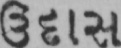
ઉદાસ
